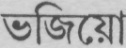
ভজিয়ো
